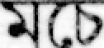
মচে
